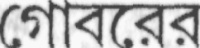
গোবরের
